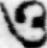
ও
